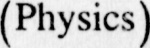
(Physics)
